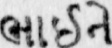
ભાઈને
